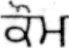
ਕੌਮ
